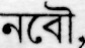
নবৌ,
